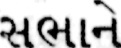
સભાને
